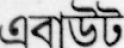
এবাউট
